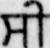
ਸੀ
